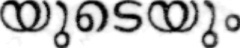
യുടെയും
